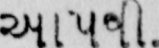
આપવી.
